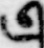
এ
